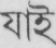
যাই
